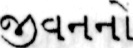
જીવનનો
